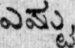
ಎಷ್ಟು
